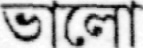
ভালো
